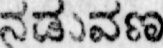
ನಡುವಣ
